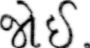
જોઈ.
